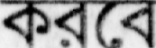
করবে
